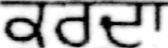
ਕਰਦਾ
